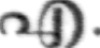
എ.
